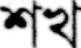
শখ
